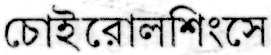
চোইরোলশিংসে
